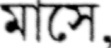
মাসে,
